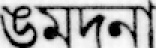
ঙমদনা
